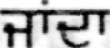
ਜਾਂਦਾ
